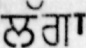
ਲੱਗਾ
